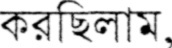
করছিলাম,
